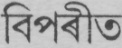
বিপৰীত
